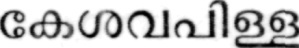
കേശവപിള്ള
